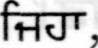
ਜਿਹਾ,
